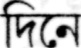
দিনে
